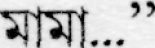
মামা..."
